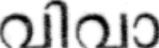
വിവാ
